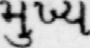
મુખ્ય
